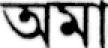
অমা
